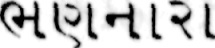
ભણનારા
